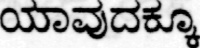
ಯಾವುದಕ್ಕೂ
